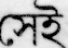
সেই
